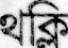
থক্লি
